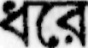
ধরে
